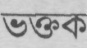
ভক্তক
